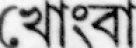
খোংবা
